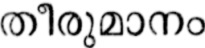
തീരുമാനം
